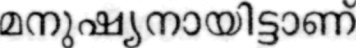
മനുഷ്യനായിട്ടാണ്
